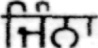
ਜਿੰਨਾ
